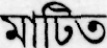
মাটিত
